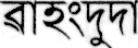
ৱাহংদুদা
